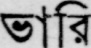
ভারি
